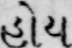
હોય
